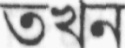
তখন
